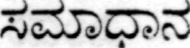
ಸಮಾಧಾನ
